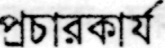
প্রচারকার্য
